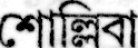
শোল্লিবা
